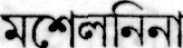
মশেলনিনা
